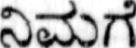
ನಿಮಗೆ
